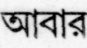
আবার
